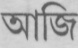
আজি
